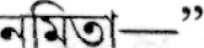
নমিতা-"
